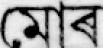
মোৰ
